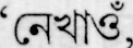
'নেখাওঁ,
